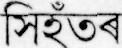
সিহঁতৰ
